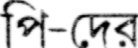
পি-দের
